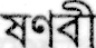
ষণবী
